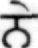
ਨੇ
